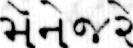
મૅનેજરે
